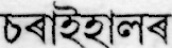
চৰাইহালৰ
